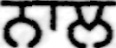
ਨਾਲ
